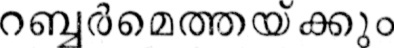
റബ്ബര്‍മെത്തയ്ക്കും
